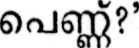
പെണ്ണ്?’
